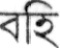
বহি
